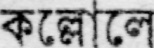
কল্লোলে
